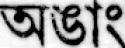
অঙাং
